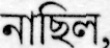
নাছিল,
